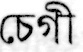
চেগী
